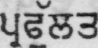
ਪ੍ਰਫੁੱਲਤ
